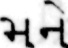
મને
